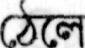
ঠেলে
